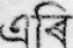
এৰি
